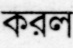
করল
